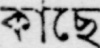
কাছে
